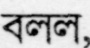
বলল,
